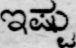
ಇಷ್ಟು
